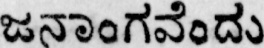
ಜನಾಂಗವೆಂದು
